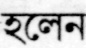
হলেন
